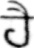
ਹੈ
